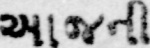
આજની
